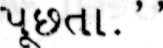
પૂછતા."
